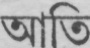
আতি
